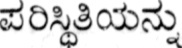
ಪರಿಸ್ಥಿತಿಯನ್ನು
